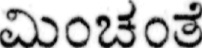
ಮಿಂಚಂತೆ
